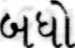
બધો
